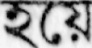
হয়ে
